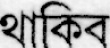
থাকিব
